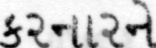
કરનારને
